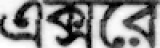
এক্সরে
